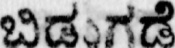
ಬಿಡುಗಡೆ
